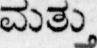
ಮತ್ತು
